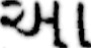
આ
